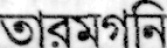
তারমগনি
